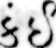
કંઈ
